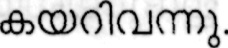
കയറിവന്നു.
